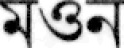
মওন
